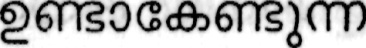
ഉണ്ടാകേണ്ടുന്ന
